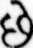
છે
